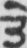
ਤੇ
